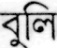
বুলি
